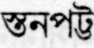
স্তনপট্ট
